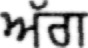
ਅੱਗ
